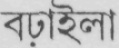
বঢ়াইলা
